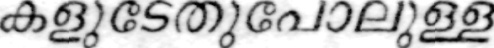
കളുടേതുപോലുള്ള
